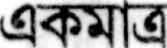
একমাত্র
